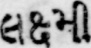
લક્ષ્મી
